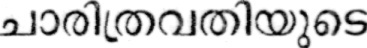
ചാരിത്രവതിയുടെ
